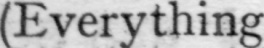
(Everything
